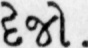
દેજો.
